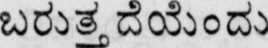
ಬರುತ್ತದೆಯೆಂದು
